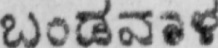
ಬಂಡವಾಳ
